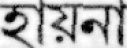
হায়না
